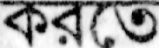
করতে
